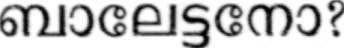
ബാലേട്ടനോ?
